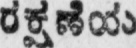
ರಕ್ಷಣೆಯ
